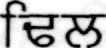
ਢਿਲ
